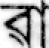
ৱা
